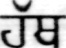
ਹੱਥ
